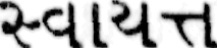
સ્વાયત્ત
